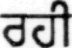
ਰਹੀ
